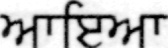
ਆਇਆ
